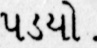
પડયો.
